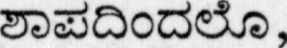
ಶಾಪದಿಂದಲೊ,
